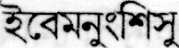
ইবেমনুংশিসু
